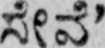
ಸೇವೆ’
